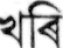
খৰি
